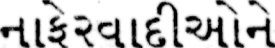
નાફેરવાદીઓને
